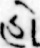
હો
